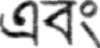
এবং
